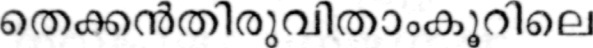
തെക്കന്‍തിരുവിതാംകൂറിലെ
